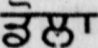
ਡੋਲਾ
